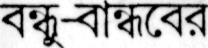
বন্ধু-বান্ধবের
